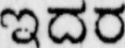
ಇದರ
